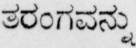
ತರಂಗವನ್ನು
